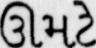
ઊમટે
